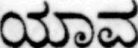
ಯಾವ
